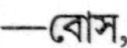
–বোস,
